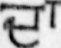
ਦਾ
